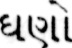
ઘણો
